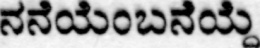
ನನೆಯೆಂಬನೆಯ್ದೆ
